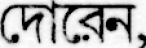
দোরেন,
